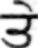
ਤੇ
